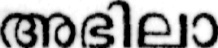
അഭിലാ
